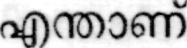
എന്താണ്
